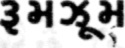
રૂમઝૂમ
